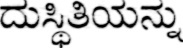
ದುಸ್ಥಿತಿಯನ್ನು
